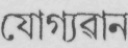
যোগ্যৱান
